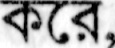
করে,
